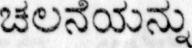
ಚಲನೆಯನ್ನು
